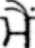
ਮੈਂ
